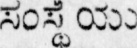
ಸಂಸ್ಥೆಯು
